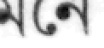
মনে
